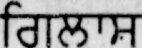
ਗਿਲਾਸ
